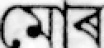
মোৰ
